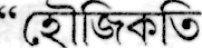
“হৌজিকতি
